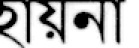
হায়না
